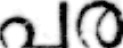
പര
